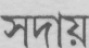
সদায়
